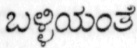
ಬಳ್ಳಿಯಂತೆ
